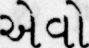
એવો
